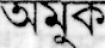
অমুক
